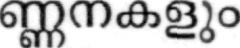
ണ്ണനകളും
